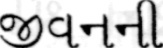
જીવનની
